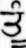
ਤੂੰ
